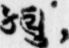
કહ્યું,
